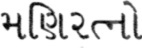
મણિરત્નો
